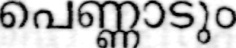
പെണ്ണാടും
